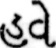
હવે
